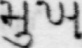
મુખ
